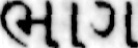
ભાગ
